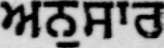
ਅਨੁਸਾਰ
